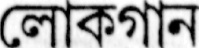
লোকগান
